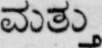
ಮತ್ತು
